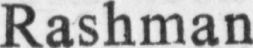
Rashman
